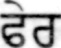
ਫੇਰ
